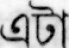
এটা
